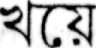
খয়ে
